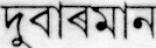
দুবাৰমান
